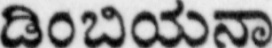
ಡಿಂಬಿಯನಾ
